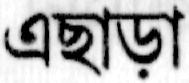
এছাড়া
